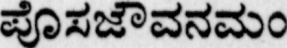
ಪೊಸಜೌವನಮಂ
